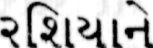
રશિયાને
